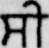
ਸੀ
